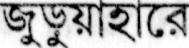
জুড়ুয়াহারে
